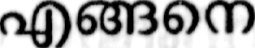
എങ്ങനെ
